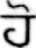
ਹੋ
